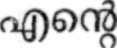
എന്റെ
